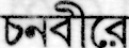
চনবীরে
